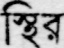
স্থির
